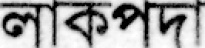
লাকপদা
